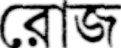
রোজ
